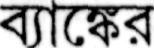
ব্যাঙ্কের
